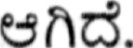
ಆಗಿದೆ.
